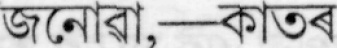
জনোৱা,-কাতৰ
